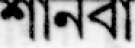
শানবা
